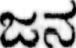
ಜನ
